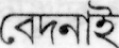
বেদনাই
